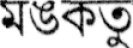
মঙকতু
